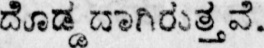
ದೊಡ್ಡದಾಗಿರುತ್ತವೆ.
